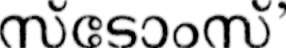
സ്ടോംസ്’
